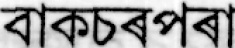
বাকচৰপৰা
